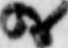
જ
